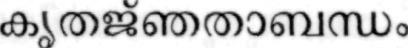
കൃതജ്ഞതാബന്ധം
